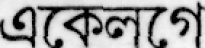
একেলগে
